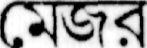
মেজর
